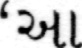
'આ
